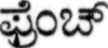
ಫ್ರೆಂಚ್
